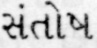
સંતોષ
